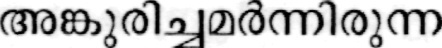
അങ്കുരിച്ചമര്‍ന്നിരുന്ന
